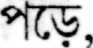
পড়ে,
